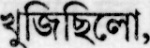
খুজিছিলো,
